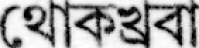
থোকখ্রবা
